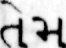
તેમ
